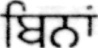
ਬਿਨਾਂ
